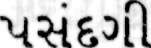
પસંદગી
